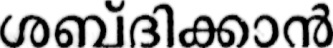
ശബ്ദിക്കാന്‍
